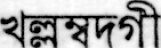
খল্লম্বদগী
